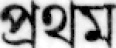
প্রথম
